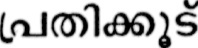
പ്രതിക്കൂട്
